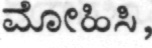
ಮೋಹಿಸಿ,
